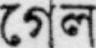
গেল
